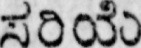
ಸರಿಯೆ
